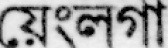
য়েংলগা
